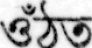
ওঁঠত
